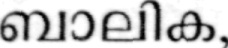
ബാലിക,
